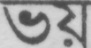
ভয়
